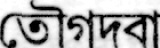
তৌগদবা
